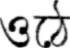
ওঠে
